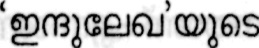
'ഇന്ദുലേഖ'യുടെ
